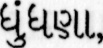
ધુંધણા,
